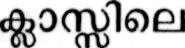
ക്ലാസ്സിലെ
